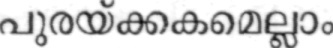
പുരയ്ക്കകമെല്ലാം
